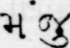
મંજુ
